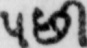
પછી
